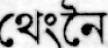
থেংনৈ
